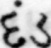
દંડ
